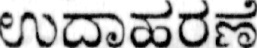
ಉದಾಹರಣೆ
